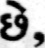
છે,
